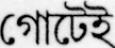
গোটেই
